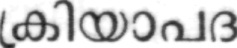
ക്രിയാപദ
